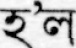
হ'ল
